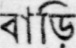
বাড়ি
